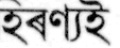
হিৰণ্যই
